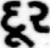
દૂર
